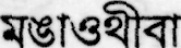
মঙাওথীবা
